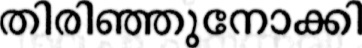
തിരിഞ്ഞുനോക്കി
